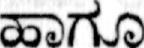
ಹಾಗೂ
